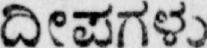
ದೀಪಗಳು
